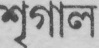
শৃগাল
